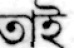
তাই
